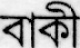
বাকী
